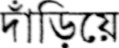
দাঁড়িয়ে
